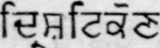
ਦ੍ਰਿਸ਼ਟਿਕੋਣ
